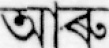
আৰু
